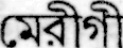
মেরীগী
